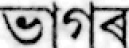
ভাগৰ
